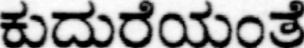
ಕುದುರೆಯಂತೆ
